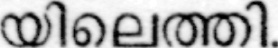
യിലെത്തി.
